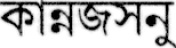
কান্নজসনু
